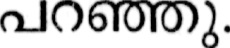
പറഞ്ഞു.
